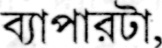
ব্যাপারটা,
